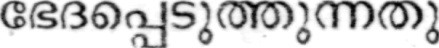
ഭേദപ്പെടുത്തുന്നതു
